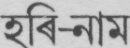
হৰি-নাম
